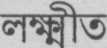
লক্ষ্মীত
